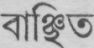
বাঞ্ছিত
